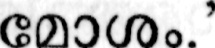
മോശം.’
